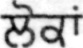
ਲੋਕਾਂ
